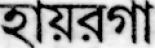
হায়রগা
